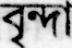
বৃন্দা
